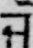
ਜੋ
